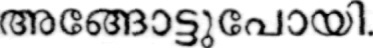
അങ്ങോട്ടുപോയി.
